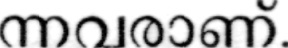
ന്നവരാണ്.
